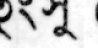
তুংসু
